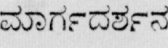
ಮಾರ್ಗದರ್ಶನ
